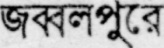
জব্বলপুরে
